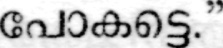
പോകട്ടെ.”
